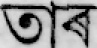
তাৰ
